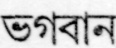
ভগবান
